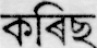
কৰিছ
